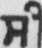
ਸੀ
